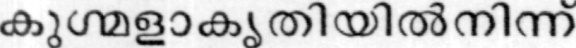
കുഗ്മളാകൃതിയില്‍നിന്ന്
